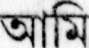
আমি
